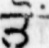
ਤੋਂ
